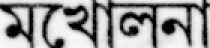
মখোলনা
